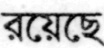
রয়েছে
